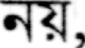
নয়,
